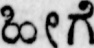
ಹೀಗೆ
